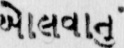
બોલવાનું
